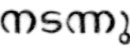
നടന്നു
